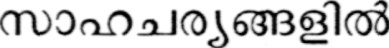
സാഹചര്യങ്ങളില്‍
